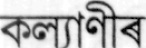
কল্যাণীৰ
